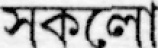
সকলো
